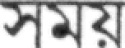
সময়
